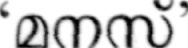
‘മനസ്'
